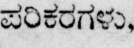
ಪರಿಕರಗಳು,
